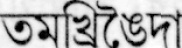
তমখ্রিঙৈদা
